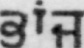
ਭਾਂਜ
